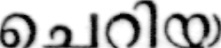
ചെറിയ
